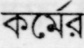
কর্মের
